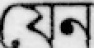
যেন
